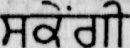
ਸਕੇਂਗੀ
